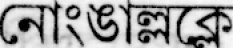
নোংঙাল্লক্লে
